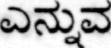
ಎನ್ನುವ
